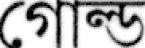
গোল্ড
